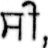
ਸੀ,
